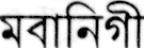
মবানিগী
